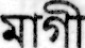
মাগী
